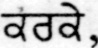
ਕਰਕੇ,
